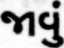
જાવું
